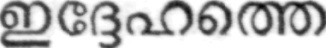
ഇദ്ദേഹത്തെ
